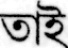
তাই
